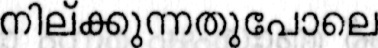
നില്ക്കുന്നതുപോലെ
